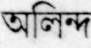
অলিন্দ
